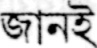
জানই
